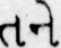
તને
